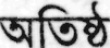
অতিষ্ঠ
